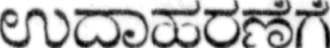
ಉದಾಹರಣೆಗೆ
